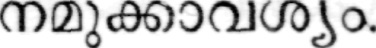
നമുക്കാവശ്യം.
